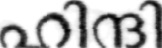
ഹിന്ദി
